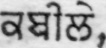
ਕਬੀਲੇ,
